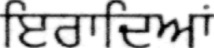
ਇਰਾਦਿਆਂ
